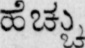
ಹೆಚ್ಚು
